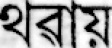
থৱায়
